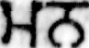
ਮਨ
